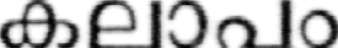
കലാപം
